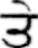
ਤੇ
